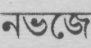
নভজে
